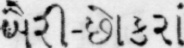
બૈરી-છોકરાં
